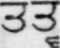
ਤਤ੍ਵ
